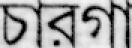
চারগা
